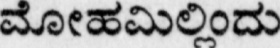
ಮೋಹಮಿಲ್ಲಿಂದು
